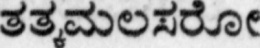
ತತ್ಕಮಲಸರೋ
